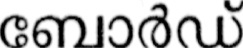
ബോര്‍ഡ്
